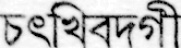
চৎখিবদগী
